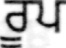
ਰੂਪ
